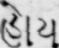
હોય
